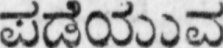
ಪಡೆಯುವ
